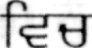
ਵਿਚ
